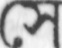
সে
